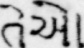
તેઓ
